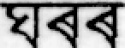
ঘৰৰ
